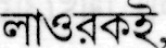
লাওরকই,
